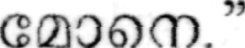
മോനെ."
